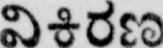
ವಿಕಿರಣ
